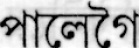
পালেগৈ
